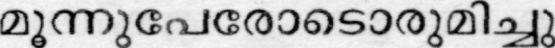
മൂന്നുപേരോടൊരുമിച്ചു
